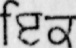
ਇਕ
